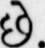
છે.
